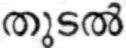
തുടല്‍
